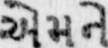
એમને
